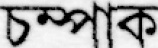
চম্পাক
